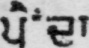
ਪੈਂਦਾ
